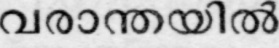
വരാന്തയില്‍
